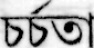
চর্চতা
